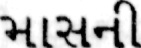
માસની
